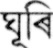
ঘূৰি
